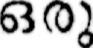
ഒരു
